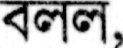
বলল,
